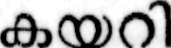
കയറി
